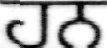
ਹਨ
